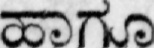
ಹಾಗೂ
